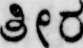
ತೀರ
